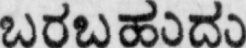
ಬರಬಹುದು
